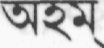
অহম্
